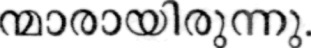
ന്മാരായിരുന്നു.
